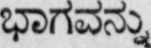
ಭಾಗವನ್ನು
